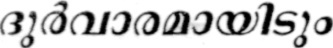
ദുര്‍വാരമായിടും
